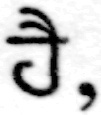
ਹੈ,
